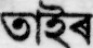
তাইৰ
